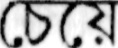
চেয়ে
